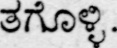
ತಗೊಳ್ಳಿ.
